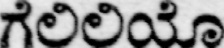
ಗೆಲಿಲಿಯೊ
